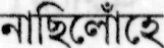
নাছিলোঁহে
